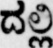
ದಲ್ಲಿ
